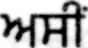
ਅਸੀਂ
